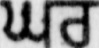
ਘਰ
